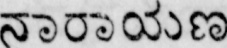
ನಾರಾಯಣ
